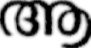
ആ
